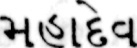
મહાદેવ
